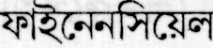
ফাইনেনসিয়েল
